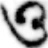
ও
